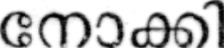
നോക്കി
